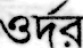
ওর্দর
